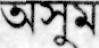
অসুম
